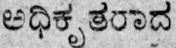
ಅಧಿಕೃತರಾದ
